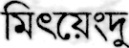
মিৎয়েংদু
